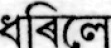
ধৰিলে
